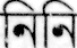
নিনি
